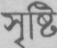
সৃষ্টি
